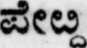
ಪೇೞ್ದ
